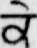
ਕੇ
